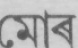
মোৰ
